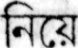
নিয়ে
